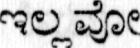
ಇಲ್ಲವೋ
